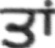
ਤਾਂ
